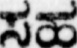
ಸಹ
